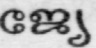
ജ്യേ
